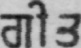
ਗੀਤ
